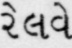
રેલવે
